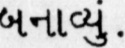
બનાવ્યું.
